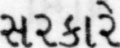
સરકારે
